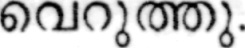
വെറുത്തു.
